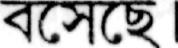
বসেছে।
